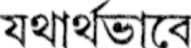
যথার্থভাবে
